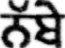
ਨੱਬੇ
